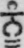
ਨੂੰ
